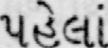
પહેલાં
